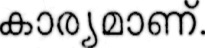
കാര്യമാണ്.
